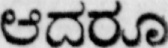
ಆದರೂ
